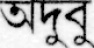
অদুবু
